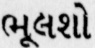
ભૂલશો
